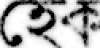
হেক
